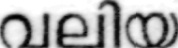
വലിയ
